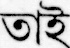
তাই
